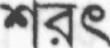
শরৎ
